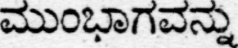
ಮುಂಭಾಗವನ್ನು
